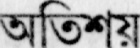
অতিশয়
